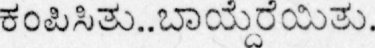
ಕಂಪಿಸಿತು..ಬಾಯ್ದೆರೆಯಿತು.
